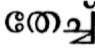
തേച്ച്
